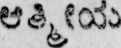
ಆತ್ಮೀಯ
